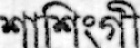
শাশিংগী
